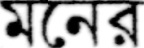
মনের
